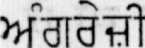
ਅੰਗਰੇਜ਼ੀ
